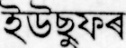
ইউছুফৰ
